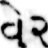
વેર
